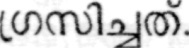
ഗ്രസിച്ചത്.
